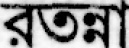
রতন্না
